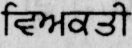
ਵਿਅਕਤੀ
